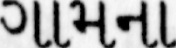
ગામના
